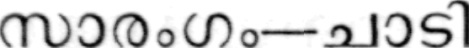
സാരംഗം-ചാടി
